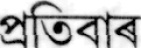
প্রতিবাৰ
